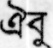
ঐবু
